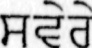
ਸਵੇਰੇ
